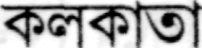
কলকাতা
